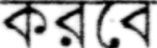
করবে
